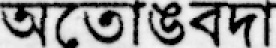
অতোঙবদা
